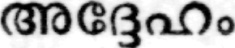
അദ്ദേഹം
